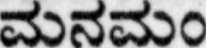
ಮನಮಂ
